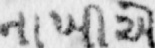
નાખીએ
